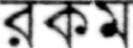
রকম
